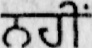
ਨਹੀਂ
